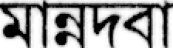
মান্নদবা
